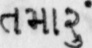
તમારું
